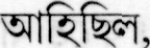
আহিছিল,
